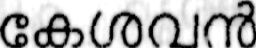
കേശവന്‍
